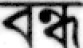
বন্ধ
